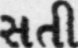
સતી
